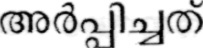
അര്‍പ്പിച്ചത്
